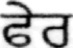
ਫੇਰ
